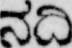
ನದಿ
